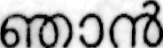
ഞാന്‍
